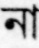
না
